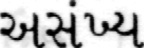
અસંખ્ય
